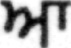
ਆ
